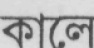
কালে
